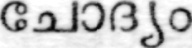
ചോദ്യം
